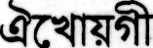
ঐখোয়গী
